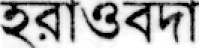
হরাওবদা
